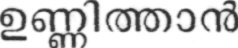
ഉണ്ണിത്താന്‍
